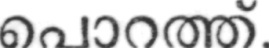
പൊറത്ത്.
